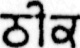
ਠੀਕ
